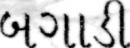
બગાડી
